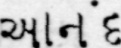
આનંદ
